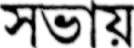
সভায়
